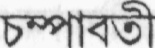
চম্পাবতী
